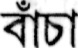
বাঁচা
